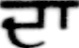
ਦਾ
